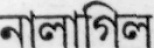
নালাগিল
